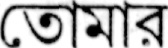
তোমার
